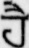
ਹੈ
